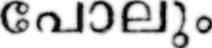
പോലും
